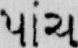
પાંચ
